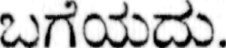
ಬಗೆಯದು.
